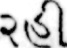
રહી
